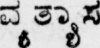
ವ್ಯತ್ಯಾಸ
